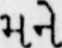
મને
